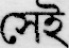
সেই
